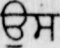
ਉਸ
